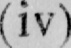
(iv)
